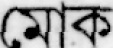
মোক
